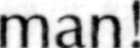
man!
